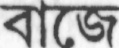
বাজে
